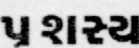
પ્રશસ્ય
